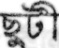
ছুটী
